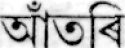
আঁতৰি
